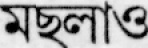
মছলাও
